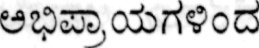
ಅಭಿಪ್ರಾಯಗಳಿಂದ
